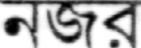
নজর
